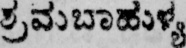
ಶ್ರಮಬಾಹುಳ್ಯ
